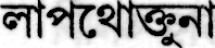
লাপথোক্তুনা
